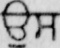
ਉਸ
